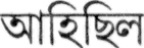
আহিছিল
